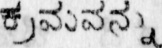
ಕ್ರಮವನ್ನು
